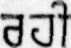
ਰਹੀ
